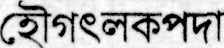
হৌগৎলকপদা
